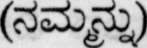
(ನಮ್ಮನ್ನು)
